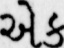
એક
